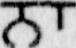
ਨਾ
